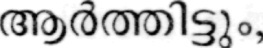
ആര്‍ത്തിട്ടും,
